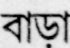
বাড়া
